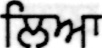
ਲਿਆ
